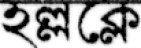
হল্লক্লে
